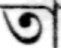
তা
